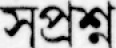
সপ্রশ্ন
